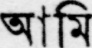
আমি
